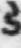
ડે
